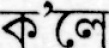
ক'লে
